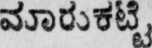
ಮಾರುಕಟ್ಟೆ
